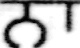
ਨਾ
